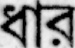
ধার
